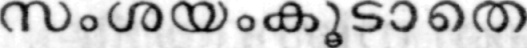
സംശയംകൂടാതെ
